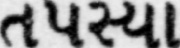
તપસ્યા
